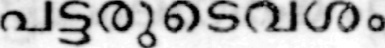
പട്ടരുടെവശം
